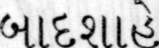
બાદશાહે
